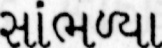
સાંભળ્યા
